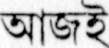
আজই
